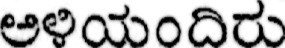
ಅಳಿಯಂದಿರು
